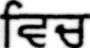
ਵਿਚ
